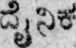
ದೈನಿಕ
